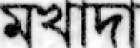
মখাদা
